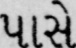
પાસે
